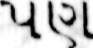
પણ
